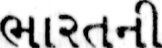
ભારતની
